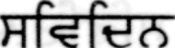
ਸਵਿਦਿਨ
